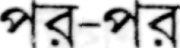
পর-পর
